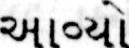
આવ્યો
